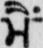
ਮੈਂ
